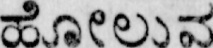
ಹೋಲುವ
